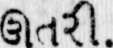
ઊતરી.
